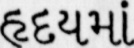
હ્રદયમાં
